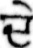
ਦੇ
